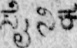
ಸೈನಿಕ
